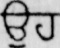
ਉਹ
